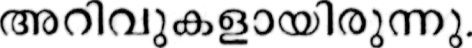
അറിവുകളായിരുന്നു.
